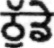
ਠੁੱਡੇ
